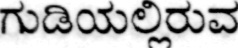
ಗುಡಿಯಲ್ಲಿರುವ
